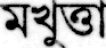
মখুত্তা
